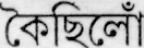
কৈছিলোঁ
